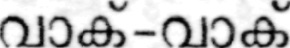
വാക്-വാക്
